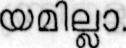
യമില്ലാ.
